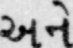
અને
